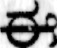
ಈ
